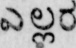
ಎಲ್ಲರ
